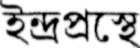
ইন্দ্রপ্রস্থে
